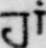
ਹਾਂ
